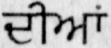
ਦੀਆਂ
